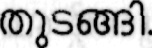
തുടങ്ങി.
